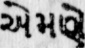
એમણે
